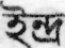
ইন্দ্ৰ
